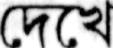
দেখে
